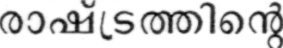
രാഷ്ട്രത്തിന്റെ
